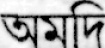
অমদি
